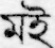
মই
